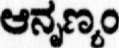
ಆನೃಣ್ಯಂ
